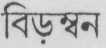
বিড়ম্বন
